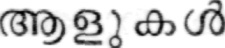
ആളുകള്‍
